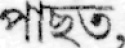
পাছত,
